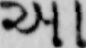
આ
